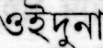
ওইদুনা
